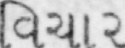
વિચાર
